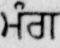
ਮੰਗ
